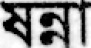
ষন্না
